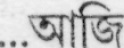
...আজি
